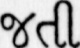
જતી
